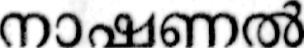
നാഷണല്‍
